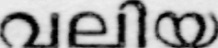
വലിയ
